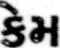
કેમ
